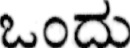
ಒಂದು
